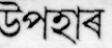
উপহাৰ
